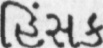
હિંસક
